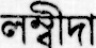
লম্বীদা
